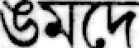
ঙমদে
